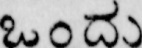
ಒಂದು
